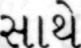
સાથે
